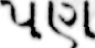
પણ
